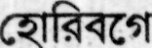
হোরিবগে
